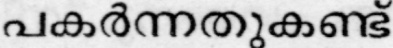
പകര്‍ന്നതുകണ്ട്
